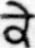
ਕੇ
